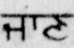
ਜਾਣ
